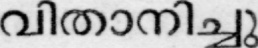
വിതാനിച്ചു
